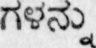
ಗಳನ್ನು
